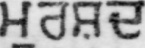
ਮੁਰਸ਼ਦ
